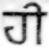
ਹੀ
